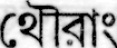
থৌরাং
